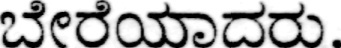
ಬೇರೆಯಾದರು.
